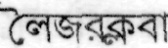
লৈজরক্লবা
